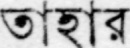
তাহার
